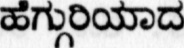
ಹೆಗ್ಗುರಿಯಾದ
